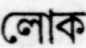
লোক
